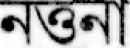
নত্তনা
